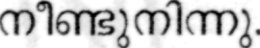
നീണ്ടുനിന്നു.
